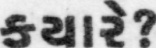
ક્યારે?
